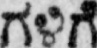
ಗಳಿಗೆ
